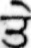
ਤੇ
